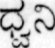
ಧ್ವನಿ
